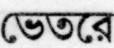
ভেতরে
